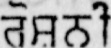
ਰੋਸ਼ਨੀ
